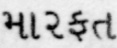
મારફત
